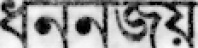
ধননজয়
